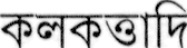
কলকত্তাদি
